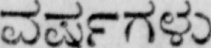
ವರ್ಷಗಳು
